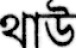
থাউ
